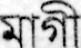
মাগী
